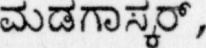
ಮಡಗಾಸ್ಕರ್,
